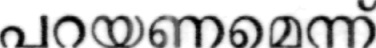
പറയണമെന്ന്
